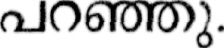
പറഞ്ഞു.
